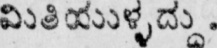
ಮಿತಿಯುಳ್ಳದ್ದು
